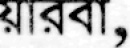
য়ারবা,
